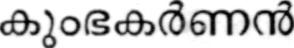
കുംഭകര്‍ണന്‍
